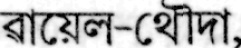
ৱায়েল-থৌদা,
